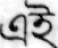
এই
